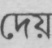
দেয়
